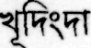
খূদিংদা
